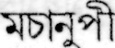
মচানুপী
